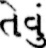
તેવું
